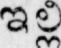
ಇಲ್ಲಿ
